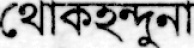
থোকহন্দুনা
